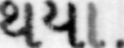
થયા.
